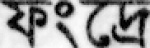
ফংদ্রে
